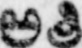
ಅತಿ
